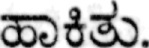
ಹಾಕಿತು.
